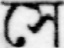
সে
